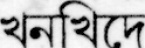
খনখিদে
